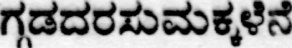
ಗ್ಗಡದರಸುಮಕ್ಕಳೆನೆ
